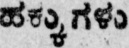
ಹಕ್ಕುಗಳು
